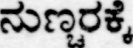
ನುಣ್ಚರಕ್ಕೆ
